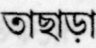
তাছাড়া
